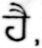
ਹੈ,
